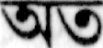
অত
